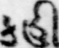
કહી
